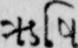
ઋષિ
